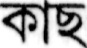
কাছ
